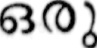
ഒരു
